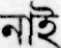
নাই
